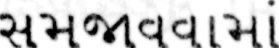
સમજાવવામાં
